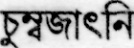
চুম্বজাৎনি
